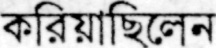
করিয়াছিলেন
